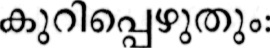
കുറിപ്പെഴുതും:
